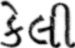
કેલી
